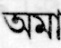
অমা
